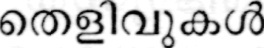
തെളിവുകള്‍
